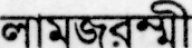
লামজরম্মী
